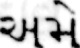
અમે
